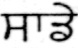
ਸਾਡੇ
